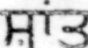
ਸ਼ਾਂਤ
